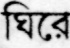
ঘিরে
